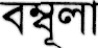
বম্বূলা
